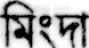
মিংদা
